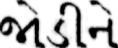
જોડીને
